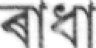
ৰাধা
